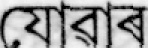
যোৱাৰ
